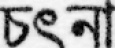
চৎনা
